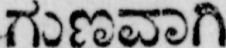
ಗುಣವಾಗಿ
